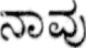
ನಾವು
